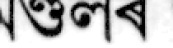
মণ্ডলৰ
